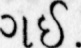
ગઈ.
